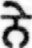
ਨੇ
